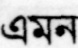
এমন
